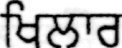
ਖਿਲਾਰ
